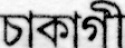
চাকাগী
